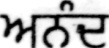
ਅਨੰਦ
